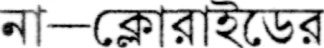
না–ক্লোরাইডের
